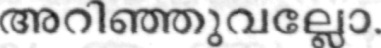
അറിഞ്ഞുവല്ലോ.
